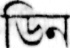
ডিন
